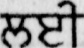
ਲਈ
